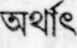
অর্থাত্
